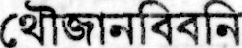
থৌজানবিবনি
